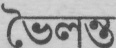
ভৈলন্ত
